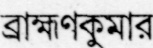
ব্রাহ্মণকুমার
